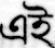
এই
